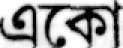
একো
